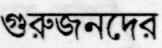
গুরুজনদের
